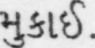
મુકાઈ.
